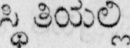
ಸ್ಥಿತಿಯಲ್ಲಿ
